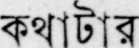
কথাটার
